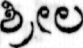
ಶ್ರೀಲ
